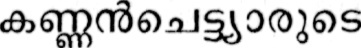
കണ്ണന്‍ചെട്ട്യാരുടെ
